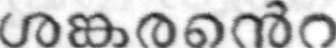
ശങ്കരന്റെ
